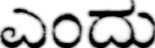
ಎಂದು
